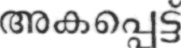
അകപ്പെട്ട്
